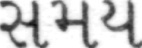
સમય
